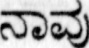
ನಾವು
